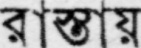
রাস্তায়
